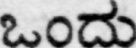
ಒ೦ದು
